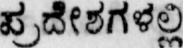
ಪ್ರದೇಶಗಳಲ್ಲಿ
